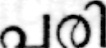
പരി
